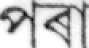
পৰা
